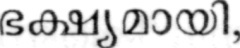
ഭക്ഷ്യമായി,
